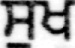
ਸੁਖ
